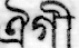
ঐগী
